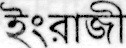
ইংরাজী
